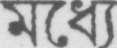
মধ্যে
